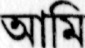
আমি
